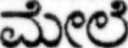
ಮೇಲೆ
